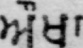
ਔਖਾ
